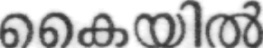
കൈയില്‍
